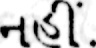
નહીં.
